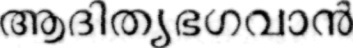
ആദിത്യഭഗവാന്‍
